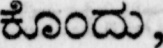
ಕೊಂದು,
